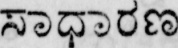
ಸಾಧಾರಣ
